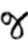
જ
